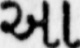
આ
